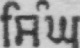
ਸਿੰਘ
